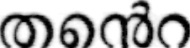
തന്റെ
